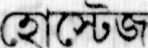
হোস্টেজ
